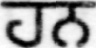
ਹਨ
